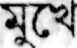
মুখে
